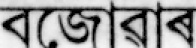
বজোৱাৰ
